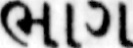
ભાગ
